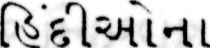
હિંદીઓના
